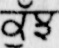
ਕੁੱਝ
